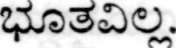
ಭೂತವಿಲ್ಲ.
